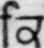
ਕਿ
